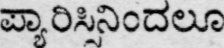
ಪ್ಯಾರಿಸ್ಸಿನಿಂದಲೂ
